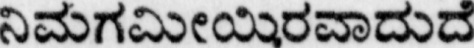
ನಿಮಗಮೀಯಿರವಾದುದೆ
